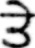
ਤੇ
